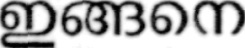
ഇങ്ങനെ
